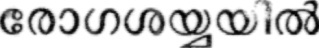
രോഗശയ്യയില്‍
